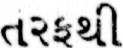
તરફથી
